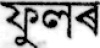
ফুলৰ
